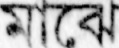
মাঝে
